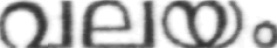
വലയം
